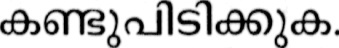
കണ്ടുപിടിക്കുക.
